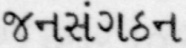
જનસંગઠન
